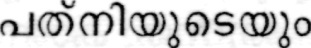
പത്നിയുടെയും
